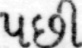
પછી
